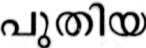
പുതിയ
